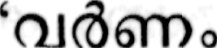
‘വര്‍ണം
